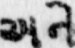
અને
